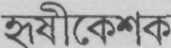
হৃষীকেশক
